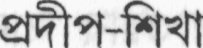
প্রদীপ-শিখা
